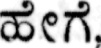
ಹೇಗೆ,
